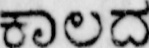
ಕಾಲದ
